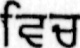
ਵਿਚ
